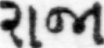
રાજા
